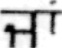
ਜਾਂ
